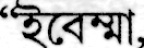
“ইবেম্মা,
